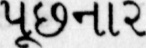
પૂછનાર
